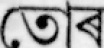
তোৰ
